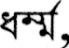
ধর্ম্ম,
